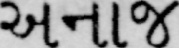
અનાજ
